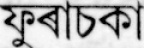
ফুৰাচকা
